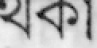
থকা
